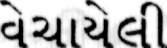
વેચાયેલી
